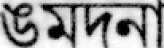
ঙমদনা
